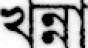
খন্না
